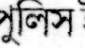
পুলিস
